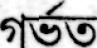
গর্ভত
